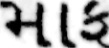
માફ
